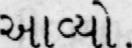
આવ્યો.
